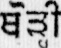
ਥੋੜ੍ਹੀ
